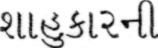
શાહુકારની
